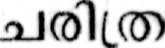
ചരിത്ര
